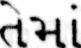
તેમાં
